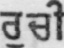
ਰੁਚੀ
